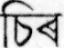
চিৰ
